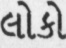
લોકો
